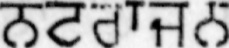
ਨਟਰਾਜਨ
